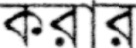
করার
